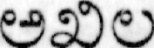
ಅಖಿಲ
